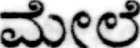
ಮೇಲೆ
